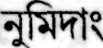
নুমিদাং
